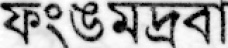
ফংঙমদ্রবা
